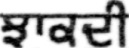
ਝਾਕਦੀ
